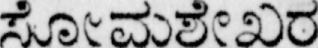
ಸೋಮಶೇಖರ
